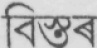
বিস্তৰ
